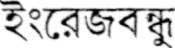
ইংরেজবন্ধু
